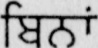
ਬਿਨਾਂ
